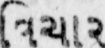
વિચાર
